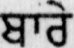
ਬਾਰੇ
